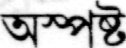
অস্পষ্ট
